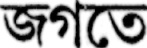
জগতে
